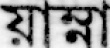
য়াম্না
